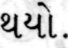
થયો.
